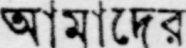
আমাদের
